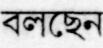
বলছেন
